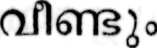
വീണ്ടും
